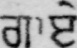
ਗਾਏ
